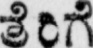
ತೆರಿಗೆ
